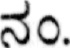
ನಂ.
